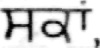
ਸਕਾਂ,
